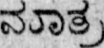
ಮಾತ್ರ
